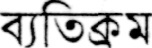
ব্যতিক্রম
